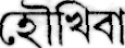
হৌখিবা
